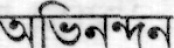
অভিনন্দন
